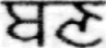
ਬਣ
